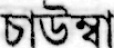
চাউম্বা
